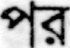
পর
